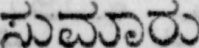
ಸುಮಾರು
